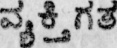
ವ್ಯಕ್ತಿಗತ
